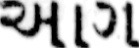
આગ
